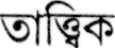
তাত্ত্বিক
